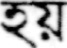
হয়
